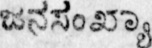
ಜನಸಂಖ್ಯಾ
